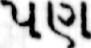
પણ
